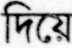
দিয়ে
